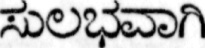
ಸುಲಭವಾಗಿ
